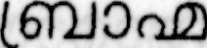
ബ്രാഹ്മ
